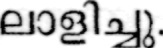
ലാളിച്ചു.
